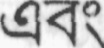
এবং
